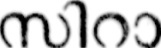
സിറാ
